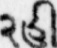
રહી
